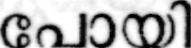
പോയി
